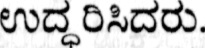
ಉದ್ಧರಿಸಿದರು.
